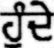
ਹੁੰਦੇ
